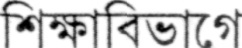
শিক্ষাবিভাগে
